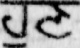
ਹੁਣ
